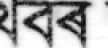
খবৰ
